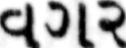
વગર
